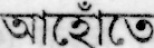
আহোঁতে
